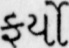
ફર્યો
